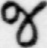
જ
